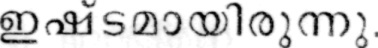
ഇഷ്ടമായിരുന്നു.
